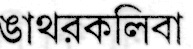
ঙাথরকলিবা
